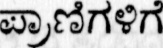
ಪ್ರಾಣಿಗಳಿಗೆ
